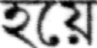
হয়ে
